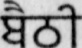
ਬੈਠੀ
